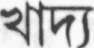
খাদ্য
